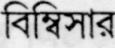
বিম্বিসার
